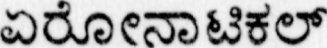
ಏರೋನಾಟಿಕಲ್
